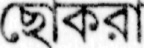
ছোকরা
